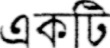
একটি
